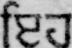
ਇਹ
